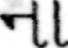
ના
